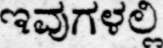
ಇವುಗಳಲ್ಲಿ
